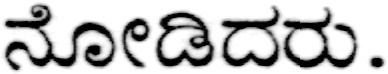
ನೋಡಿದರು.
